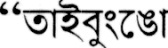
“তাইবুংঙো
